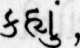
કહ્યું,
